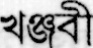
খঞ্জবী
